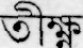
তীক্ষ্ণ
